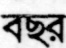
বছর
